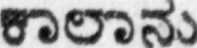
ಕಾಲಾನು
